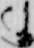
તુ
